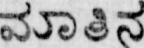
ಮಾತಿನ
